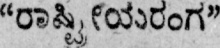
“ರಾಷ್ಟ್ರೀಯರಂಗ”
